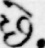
છે.
